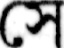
সে
